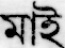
মাই
